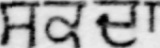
ਸਕਦਾ
